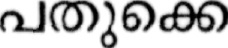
പതുക്കെ
